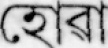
হোৱা
